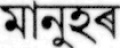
মানুহৰ
